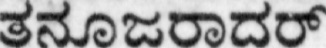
ತನೂಜರಾದರ್
